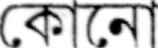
কোনো
